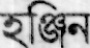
হঞ্জিন
